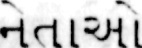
નેતાઓ
